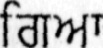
ਗਿਆ
